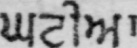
ਘਟੀਆ
